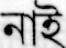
নাই
